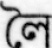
লৈ
